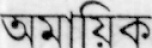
অমায়িক
